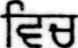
ਵਿਚ
